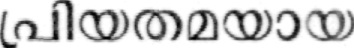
പ്രിയതമയായ
